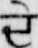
ਦੇ
